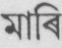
মাৰি
